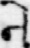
ને
